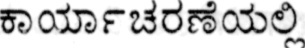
ಕಾರ್ಯಾಚರಣೆಯಲ್ಲಿ
